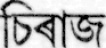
চিৰাজ
